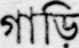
গাড়ি
